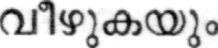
വീഴുകയും
